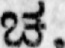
ಚ.
